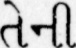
તેની
